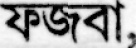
ফজবা,
